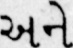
અને
